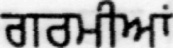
ਗਰਮੀਆਂ
